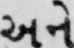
અને
